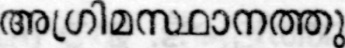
അഗ്രിമസ്ഥാനത്തു
